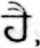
ਹੈ,
